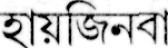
হায়জিনবা
